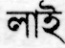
লাই
